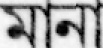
মানা
